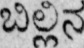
ಬಿಲ್ಲಿನ
